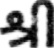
શ્રી
